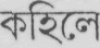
কহিলে
